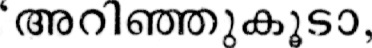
'അറിഞ്ഞുകൂടാ,
